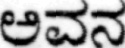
ಅವನ
